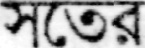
সতের
